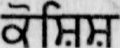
ਕੋਸ਼ਿਸ਼
